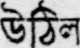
উঠিল
